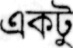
একটু
